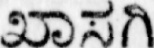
ಖಾಸಗಿ
